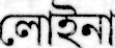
লোইনা
